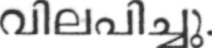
വിലപിച്ചു.
